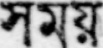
সময়
